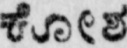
ಕೋಶ
